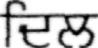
ਦਿਲ
